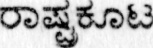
ರಾಷ್ಟ್ರಕೂಟ
